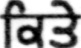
ਕਿਤੇ
